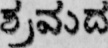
ಶ್ರಮದ
